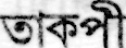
তাকপী
